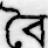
বৈ
